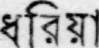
ধরিয়া
